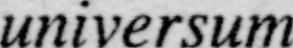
universum
